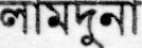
লামদুনা
